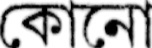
কোনো
